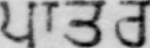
ਪਾਤਰ
